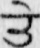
ਤੇ
